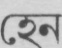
হেন
